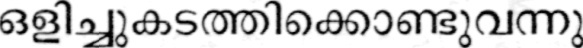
ഒളിച്ചുകടത്തിക്കൊണ്ടുവന്നു
